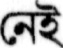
নেই
